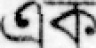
এক
